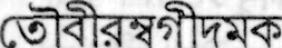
তৌবীরম্বগীদমক
